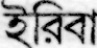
ইরিবা
